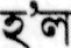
হ'ল
